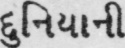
દુનિયાની
